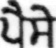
ਪੈਸੇ
